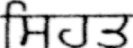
ਸਿਹਤ
